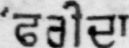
'ਫਰੀਦਾ
